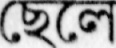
ছেলে
